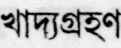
খাদ্যগ্রহণ
